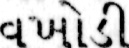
વખોડી
